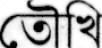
তৌখি
